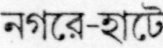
নগরে-হাটে
